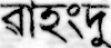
ৱাহংদু
